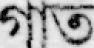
গাত
